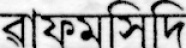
ৱাফমসিদি
